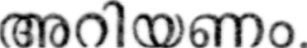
അറിയണം.
